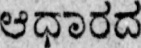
ಆಧಾರದ
